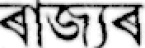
ৰাজ্যৰ
